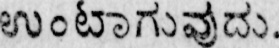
ಉಂಟಾಗುವುದು.
